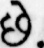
છે.
